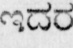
ಇದರ
